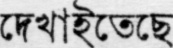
দেখাইতেছে
